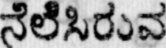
ನೆಲೆಸಿರುವ
